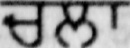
ਚਲਾ
